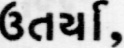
ઉતર્યા,
